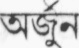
অর্জুন
